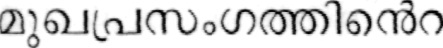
മുഖപ്രസംഗത്തിന്റെ
